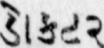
ડોક્ટર
